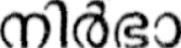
നിര്‍ഭാ
